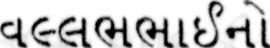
વલ્લભભાઈનો
